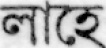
লাহে
